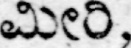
ಮೀರಿ,
